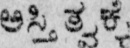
ಅಸ್ತಿತ್ವಕ್ಕೆ
